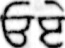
ਓਏ
